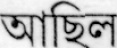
আছিল
